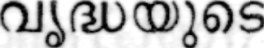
വൃദ്ധയുടെ
